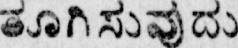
ತೂಗಿಸುವುದು
